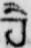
ਹੈ
